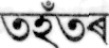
তহঁতৰ
